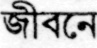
জীবনে
